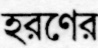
হরণের
